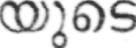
യുടെ
